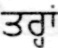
ਤਰ੍ਹਾਂ
